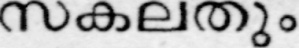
സകലതും
